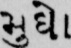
મુઘો
